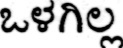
ಒಳಗಿಲ್ಲ
